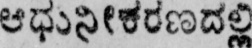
ಆಧುನೀಕರಣದಲ್ಲಿ
